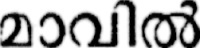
മാവില്‍
